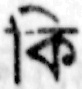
কি
